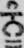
ਨੂੰ
